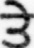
ਤੇ
